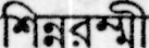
শিন্নরম্মী
